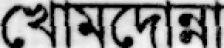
খোমদোন্না
